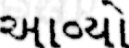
આવ્યો
